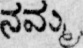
ನಮ್ಮ
